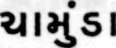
ચામુંડા
